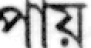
পায়
